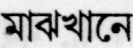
মাঝখানে
